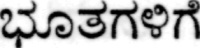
ಭೂತಗಳಿಗೆ
